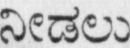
ನೀಡಲು
